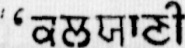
''ਕਲਯਾਣੀ
